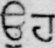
ਉਹ
